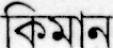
কিমান
